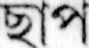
ছাপ
